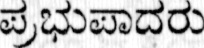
ಪ್ರಭುಪಾದರು
